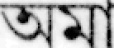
অমা
